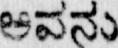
ಅವನು
